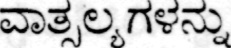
ವಾತ್ಸಲ್ಯಗಳನ್ನು
